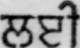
ਲਈ
